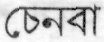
চেনবা
